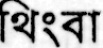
থিংবা
